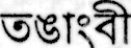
তঙাংবী
